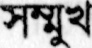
সন্মুখ
